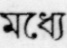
মধ্যে
